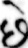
છે
